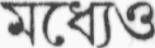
মধ্যেও
